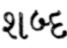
શબ્દ
